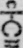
ਨੂੰ
